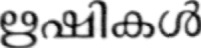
ഋഷികള്‍
